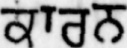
ਕਾਰਨ
